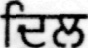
ਦਿਲ
